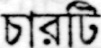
চারটি
